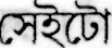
সেইটো
